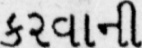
કરવાની
